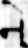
ને
